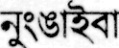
নুংঙাইবা
